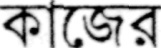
কাজের
